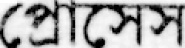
প্রোসেস
